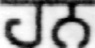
ਹਨ
